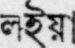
লইয়া
